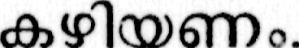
കഴിയണം.
